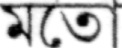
মতো
